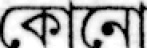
কোনো
